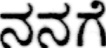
ನನಗೆ
